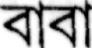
বাবা
